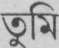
তুমি
